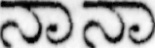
ನಾನಾ
